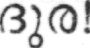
ദുര!
